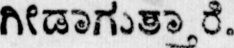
ಗೀಡಾಗುತ್ತಾರೆ.
